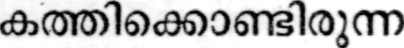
കത്തിക്കൊണ്ടിരുന്ന
